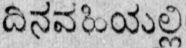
ದಿನವಹಿಯಲ್ಲಿ
